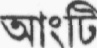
আংটি
